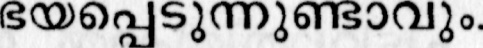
ഭയപ്പെടുന്നുണ്ടാവും.
